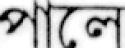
পালে
